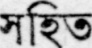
সহিত
